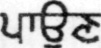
ਪਾਉਣ
